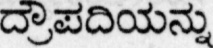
ದ್ರೌಪದಿಯನ್ನು
